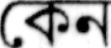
কেন
